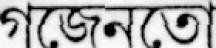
গজেনতো
